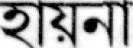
হায়না
